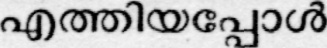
എത്തിയപ്പോള്‍
